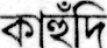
কাহুঁদি
